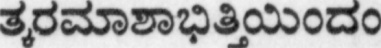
ತ್ಕರಮಾಶಾಭಿತ್ತಿಯಿಂದಿಂ
